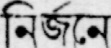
নির্জনে
